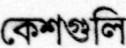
কেশগুলি
